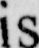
is
